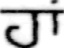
ਹਾਂ
